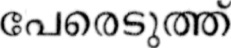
പേരെടുത്ത്
